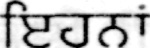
ਇਹਨਾਂ
